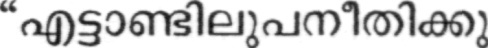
“എട്ടാണ്ടിലുപനീതിക്കു
